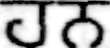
ਹਨ
